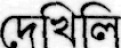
দেখিলি
